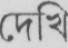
দেখি
